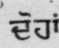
ਦੋਹਾਂ
